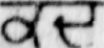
ਕਦ
